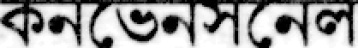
কনভেনসনেল
